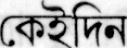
কেইদিন
